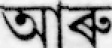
আৰু
